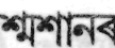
শ্মশানৰ
